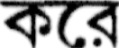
করে
